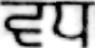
ਵਧ
